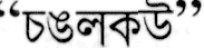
“চঙলকউ”
